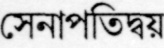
সেনাপতিদ্বয়
